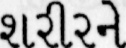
શરીરને
